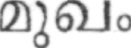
മുഖം
